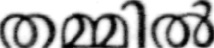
തമ്മില്‍
